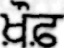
ਖ਼ੌਫ਼
